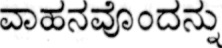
ವಾಹನವೊಂದನ್ನು
